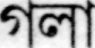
গলা
